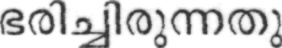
ഭരിച്ചിരുന്നതു
